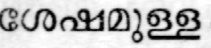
ശേഷമുള്ള
